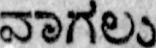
ವಾಗಲು
